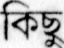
কিছু
